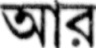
আর
